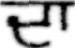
ਦਾ
